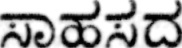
ಸಾಹಸದ
